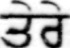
ਤੇਰੇ
